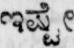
ಇಷ್ಟೇ
